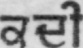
ਕਦੀ
